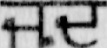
ਜਦ
